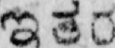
ಇತರ
